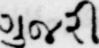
ગુજરી
